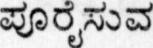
ಪೂರೈಸುವ
